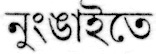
নুংঙাইতে
